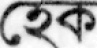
হেক
